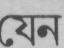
যেন
